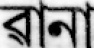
ৱানা
